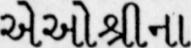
એઓશ્રીના
